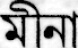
মীনা
